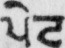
ਪੇਟ
